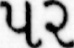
પર
